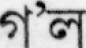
গ'ল
